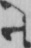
ને
